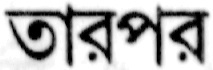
তারপর
